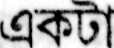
একটা
